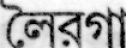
লৈরগা
